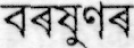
বৰষুণৰ
